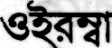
ওইরম্বা
